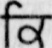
ਕਿ
